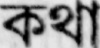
কথা
